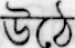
উঠে
